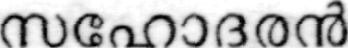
സഹോദരന്‍
